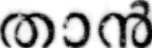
താന്‍
